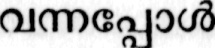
വന്നപ്പോള്‍
